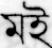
মই
